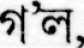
গ'ল,
